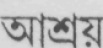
আশ্রয়
